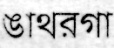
ঙাথরগা
